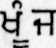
ਖੂੰਜ
